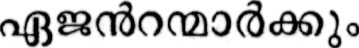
ഏജന്‍റന്മാര്‍ക്കും
